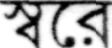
স্বরে
